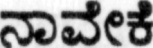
ನಾವೇಕೆ
